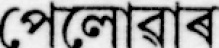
পেলোৱাৰ
